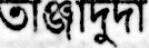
তাঞ্জাদুদা
